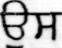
ਉਸ
